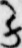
કે
